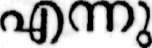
എന്നു
